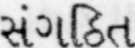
સંગઠિત
